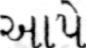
આપે
